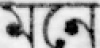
মনে
